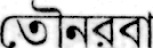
তৌনরবা
